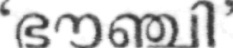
'ഭൗഞ്ചി'
